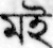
মই
